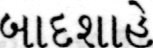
બાદશાહે
